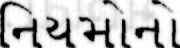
નિયમોનો
